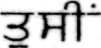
ਤੁਸੀਂ
